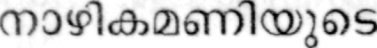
നാഴികമണിയുടെ
